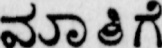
ಮಾತಿಗೆ
